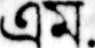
এম.
